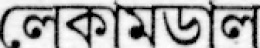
লেকামডাল
